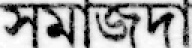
সমাজদা
